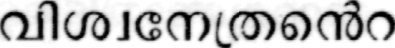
വിശ്വനേത്രന്റെ
